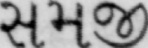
સમજી
